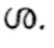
ശ.
